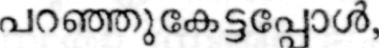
പറഞ്ഞുകേട്ടപ്പോള്‍,
